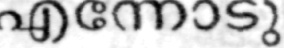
എന്നോടു
